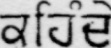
ਕਹਿੰਦੇ
